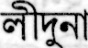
লীদুনা
